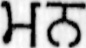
ਮਨ
